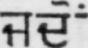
ਜਦੋਂ
